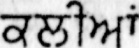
ਕਲੀਆਂ
